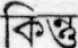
কিন্তু
